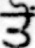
ਤੋਂ
